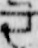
ਦੋ
